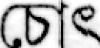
চোৎ
